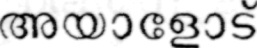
അയാളോട്
